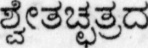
ಶ್ವೇತಚ್ಛತ್ರದ
